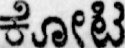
ಕೋಟಿ
